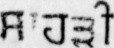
ਸਾਹੜੀ
